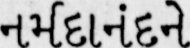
નર્મદાનંદને
